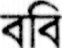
ববি
